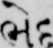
ભેદ
